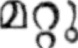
മറ്റു
